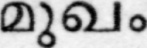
മുഖം
